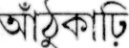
আঁঠুকাঢ়ি
